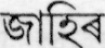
জাহিৰ
